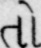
તો
